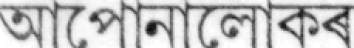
আপোনালোকৰ
